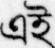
এই
